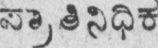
ಪ್ರಾತಿನಿಧಿಕ
